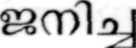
ജനിച്ച
